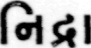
નિદ્રા
